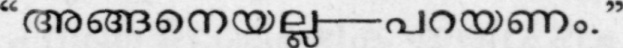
"അങ്ങനെയല്ല-പറയണം."
